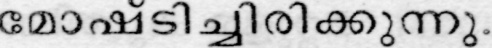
മോഷ്ടിച്ചിരിക്കുന്നു.
